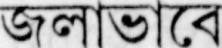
জলাভাবে
